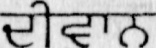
ਦੀਵਾਨ
